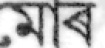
মোৰ
